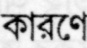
কারণে
